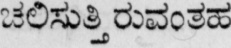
ಚಲಿಸುತ್ತಿರುವಂತಹ
